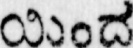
ಯಿಂದ
